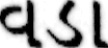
વડા
